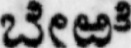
ಬೇಱೆ
